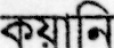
কয়ানি
